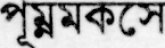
পূম্নমকসে
